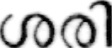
ശരി
